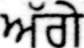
ਅੱਗੇ
